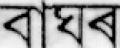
বাঘৰ
